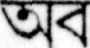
অব
